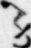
કે
